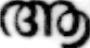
ആ
